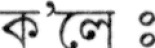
ক'লেঃ
